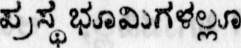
ಪ್ರಸ್ಥಭೂಮಿಗಳಲ್ಲೂ
